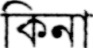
কিনা
